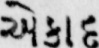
એકાદ
